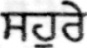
ਸਹੁਰੇ
